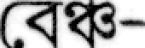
বেঞ্চ-
